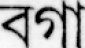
বগা
